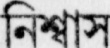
নিশ্বাস
